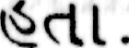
હતા.
